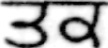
ਤਕ
